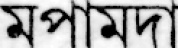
মপামদা
